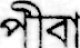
পীবা
